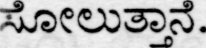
ಸೋಲುತ್ತಾನೆ.
